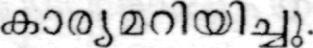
കാര്യമറിയിച്ചു.
